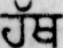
ਹੱਥ
